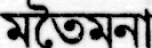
মতৈমনা
